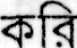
করি
